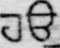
ਹਉ
